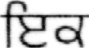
ਇਕ
